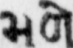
મળે
